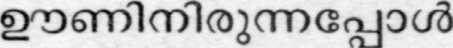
ഊണിനിരുന്നപ്പോള്‍
